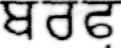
ਬਰਫ਼
